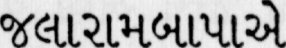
જલારામબાપાએ
